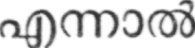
എന്നാല്‍
